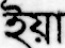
ইয়া
